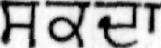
ਸਕਦਾ
